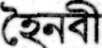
হৈনবী
